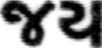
જય
